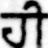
ਹੀ
